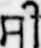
ਸੀ
